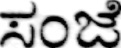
ಸಂಜೆ
